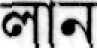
লান
